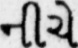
નીચે
